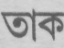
তাক
